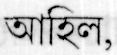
আহিল,
